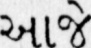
આજે
